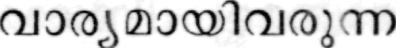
വാര്യമായിവരുന്ന
